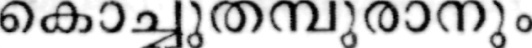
കൊച്ചുതമ്പുരാനും
